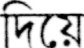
দিয়ে
